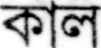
কাল
